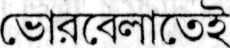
ভোরবেলাতেই
